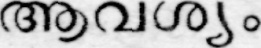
ആവശ്യം
